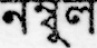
নম্বুল
